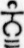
ਨੂੰ
